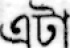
এটা
